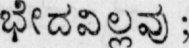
ಭೇದವಿಲ್ಲವು;
